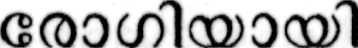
രോഗിയായി
